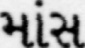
માંસ
